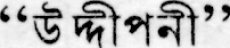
“উদ্দীপনী”
